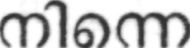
നിന്നെ
